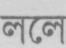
ললে
